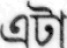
এটা
